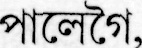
পালেগৈ,
